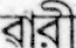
ৱারী
